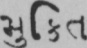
મુક્તિ
